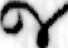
જ
